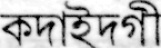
কদাইদগী
